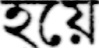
হয়ে
